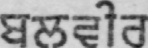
ਬਲਵੀਰ
